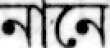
নানে
